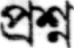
প্রশ্ন
